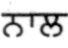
ਨਾਲ
